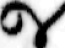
જ
